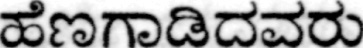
ಹೆಣಗಾಡಿದವರು
